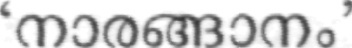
‘നാരങ്ങാനം’
